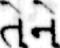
તેને
